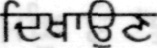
ਦਿਖਾਉਣ
